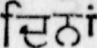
ਦਿਨਾਂ
